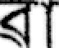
ৱা
